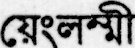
য়েংলম্মী
